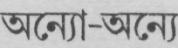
অন্যো-অন্যে
